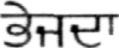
ਭੇਜਦਾ
